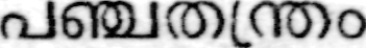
പഞ്ചതന്ത്രം
